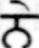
ਨੇ
